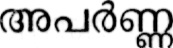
അപര്‍ണ്ണ
